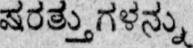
ಷರತ್ತುಗಳನ್ನು
